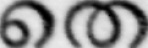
തെ
